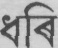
ধৰি
